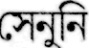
সেনুনি
